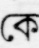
কে
